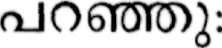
പറഞ്ഞു:
